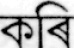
কৰি
